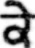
ਕੇ
